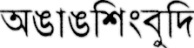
অঙাঙশিংবুদি
